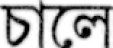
চালে
